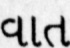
વાત
